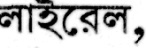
লাইরেল,
